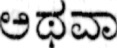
ಅಥವಾ
